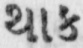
થાક
